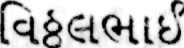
વિઠ્ઠલભાઈ
